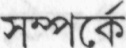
সম্পর্কে
